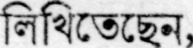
লিখিতেছেন,
